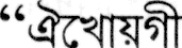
“ঐখোয়গী
